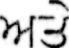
ਅਤੇ
